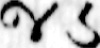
જડ
